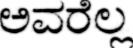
ಅವರೆಲ್ಲ
